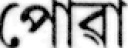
পোৱা
